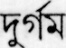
দুর্গম
